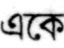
একে
